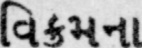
વિક્રમના
